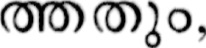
ത്തതും,
